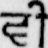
ਵੀ
